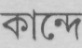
কান্দে
